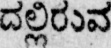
ದಲ್ಲಿರುವ
